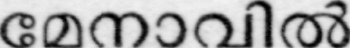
മേനാവില്‍
